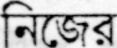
নিজের
